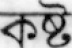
কষ্ট
